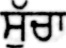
ਸੁੱਚਾ
